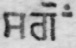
ਸਗੋਂ
